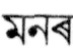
মনৰ
